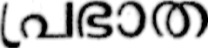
പ്രഭാത
